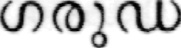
ഗരുഡ
